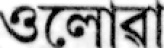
ওলোৱা
